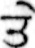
ਤੇ
